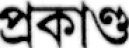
প্রকাণ্ড
